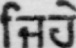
ਜਿਹੇ
